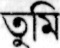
তুমি
